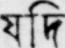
যদি
